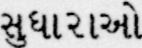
સુધારાઓ
